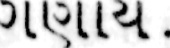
ગણાય.
